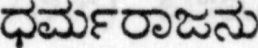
ಧರ್ಮರಾಜನು
